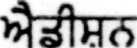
ਐਡੀਸ਼ਨ
